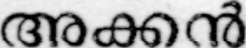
അക്കന്‍
